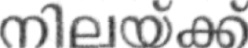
നിലയ്ക്ക്
